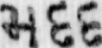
મદદ
